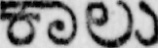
ಕಾಲು
